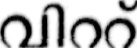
വിററ്
